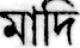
মাদি
